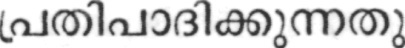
പ്രതിപാദിക്കുന്നതു
